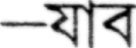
-যাব
